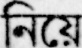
নিয়ে
